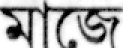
মাজে
